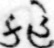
કહે
